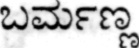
ಬರ್ಮಣ್ಣ
